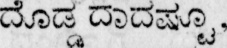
ದೊಡ್ಡದಾದಷ್ಟೂ,
